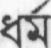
ধর্ম
